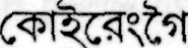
কোইরেংগৈ
